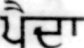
ਪੈਦਾ
